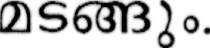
മടങ്ങും.
